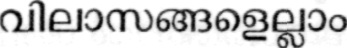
വിലാസങ്ങളെല്ലാം
